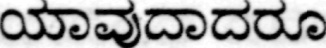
ಯಾವುದಾದರೂ
